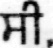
ਸੀ,
